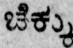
ಚೆಕ್ಕು
